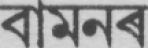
বামনৰ
